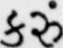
કરું
